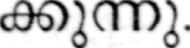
ക്കുന്നു.
